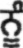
ਨੂੰ
